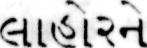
લાહોરને
